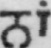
ਨਾਂ
